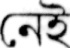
নেই
